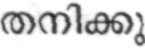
തനിക്കു
